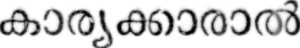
കാര്യക്കാരാല്‍
